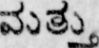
ಮತ್ತು
